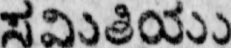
ಸಮಿತಿಯು
